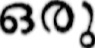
ഒരു
